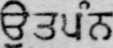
ਉਤਪੰਨ
